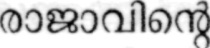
രാജാവിന്റെ
